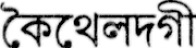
কৈথেলদগী
